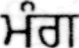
ਮੰਗ
